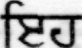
ਇਹ
